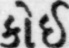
કોઈ
